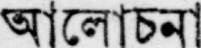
আলোচনা
